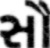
સૌ
